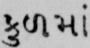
કુળમાં
